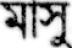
মাসু
